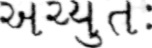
અચ્યતઃ
